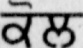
ਕੋਲ
